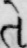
તે
